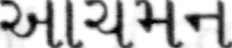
આચમન
